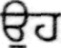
ਉਹ
